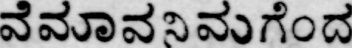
ವೆಮಾವನಿಮಗೆಂದ
